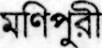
মণিপুরী
